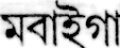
মবাইগা
